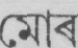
মোৰ
